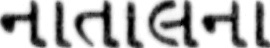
નાતાલના
